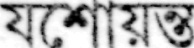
যশোয়ন্ত
